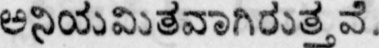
ಅನಿಯಮಿತವಾಗಿರುತ್ತವೆ.
